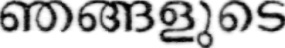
ഞങ്ങളുടെ
